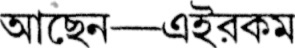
আছেন-এইরকম
